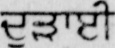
ਦੁੜਾਈ
